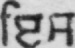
ਇਸ
